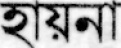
হায়না
